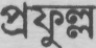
প্ৰফুল্ল
